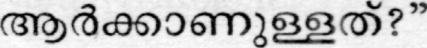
ആര്‍ക്കാണുള്ളത്?”
